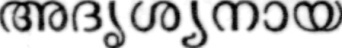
അദൃശ്യനായ
